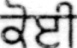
ਕੋਈ
